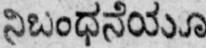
ನಿಬಂಧನೆಯೂ
